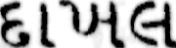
દાખલ
